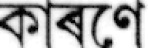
কাৰণে
